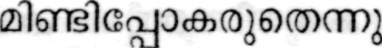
മിണ്ടിപ്പോകരുതെന്നു
